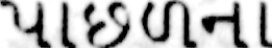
પાછળના
